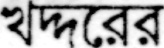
খদ্দরের
